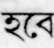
হবে
